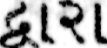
દ્વારા
